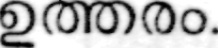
ഉത്തരം.
